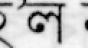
হ'ল
